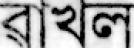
ৱাখল
